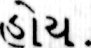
હોય.
